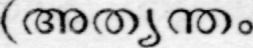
(അത്യന്തം
